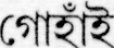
গোহাঁই
